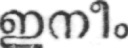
ഇനീം
